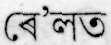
ৰেলত
